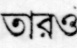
তারও
